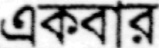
একবার
